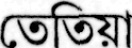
তেতিয়া
